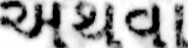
અથવા
